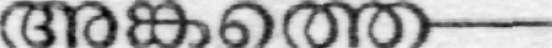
അങ്കത്തെ-
